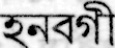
হনবগী
